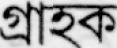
গ্ৰাহক
